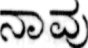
ನಾವು
